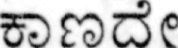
ಕಾಣದೇ
